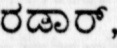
ರಡಾರ್,
